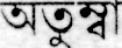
অতুম্বা
